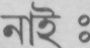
নাইঃ
